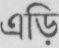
এড়ি
